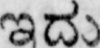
ಇದು
